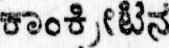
ಕಾಂಕ್ರೀಟಿನ
